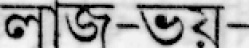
লাজ-ভয়-
